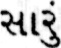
સારું
